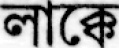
লাক্কে
